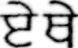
ਏਥੇ
